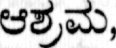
ಆಶ್ರಮ,
